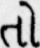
તો
